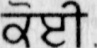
ਕੋਈ
